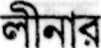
লীনার
